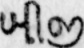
બીજી
